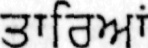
ਤਾਰਿਆਂ
